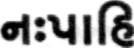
નઃપાહિ
